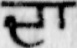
ਦਾ
